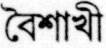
বৈশাখী
